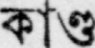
কাণ্ড
